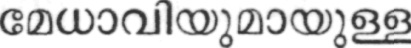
മേധാവിയുമായുള്ള
